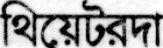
থিয়েটরদা
